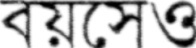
বয়সেও
